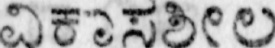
ವಿಕಾಸಶೀಲ
